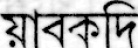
য়াবকদি
